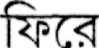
ফিরে
